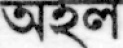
অহল
